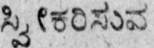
ಸ್ವೀಕರಿಸುವ
